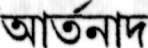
আর্তনাদ
